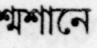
শ্মশানে
